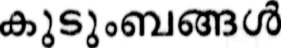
കുടുംബങ്ങള്‍
